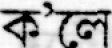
ক'লে
